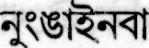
নুংঙাইনবা
